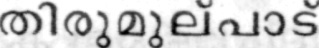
തിരുമുല്പാട്
